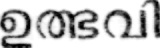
ഉത്ഭവി
